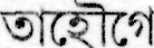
তাহৌগে
